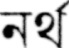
নর্থ
